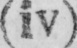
(iv)
